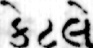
કેટલે
